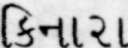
કિનારા
